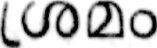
ശ്രമം
